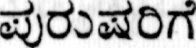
ಪುರುಷರಿಗೆ
